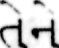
તેને
